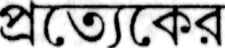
প্রত্যেকের
